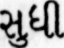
સુધી
